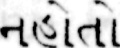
નહોતો
